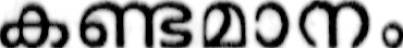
കണ്ടമാനം
